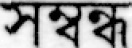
সম্বন্ধ
